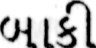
બાકી
